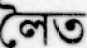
লৈত
